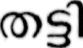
തട്ടി
